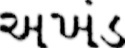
અખંડ
